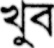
খুব
